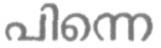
പിന്നെ
